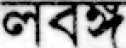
লবঙ্গ
